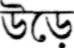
উড়ে
